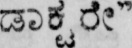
ಡಾಕ್ಟರೇ”
